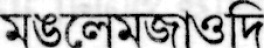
মঙলেমজাওদি
